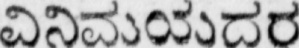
ವಿನಿಮಯದರ
